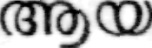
ആയ
